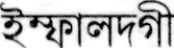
ইম্ফালদগী
